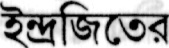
ইন্দ্রজিতের
